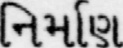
નિર્માણ
